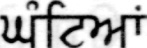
ਘੰਟਿਆਂ
